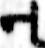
ન
